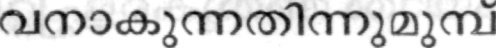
വനാകുന്നതിന്നുമുമ്പ്
